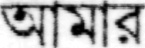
আমার
